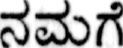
ನಮಗೆ
